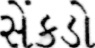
સેંકડો
